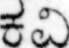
ಕವಿ
